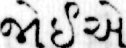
જોઈએ
